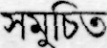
সমুচিত
